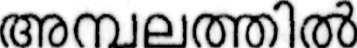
അമ്പലത്തില്‍
